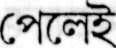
পেলেই
